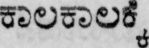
ಕಾಲಕಾಲಕ್ಕೆ
